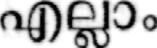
എല്ലാം
